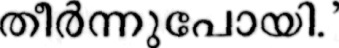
തീര്‍ന്നുപോയി.’
